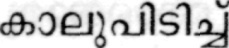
കാലുപിടിച്ച്
